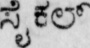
ಸೈಕಲ್
